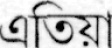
এতিয়া
